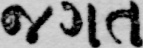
જગત
